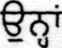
ਉਨ੍ਹਾਂ
